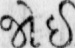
જોઈ
